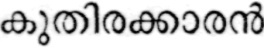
കുതിരക്കാരന്‍
